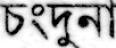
চংদুনা
